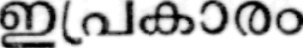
ഇപ്രകാരം
